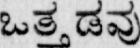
ಒತ್ತಡವು
